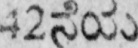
42ನೆಯ
